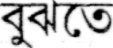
বুঝতে
